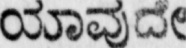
ಯಾವುದೇ
